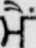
ਮੈਂ
